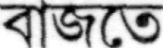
বাজতে
